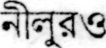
নীলুরও
